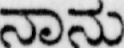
ನಾನು
